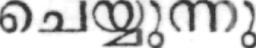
ചെയ്യുന്നു
